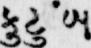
કુટુંબ
